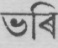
ভৰি
